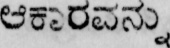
ಆಕಾರವನ್ನು
